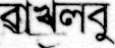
ৱাখলবু
